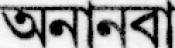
অনানবা
